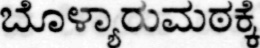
ಬೊಳ್ಯಾರುಮಠಕ್ಕೆ
